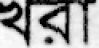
খরা
